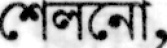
শেলনো,
